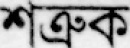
শত্রুক
